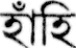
হাঁহি
